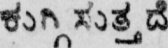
ಕುಗ್ಗಿಸುತ್ತದೆ
